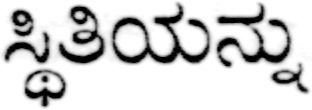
ಸ್ಥಿತಿಯನ್ನು
